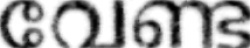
വേണ്ട
